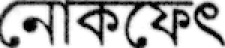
নোকফেৎ
